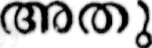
അതു
